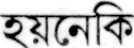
হয়নেকি
